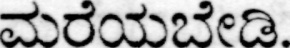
ಮರೆಯಬೇಡಿ.
